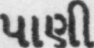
પાણી
